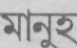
মানুহ
